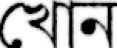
খোন
